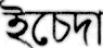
ইচেদা
